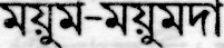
ময়ুম-ময়ুমদা
